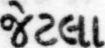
જેટલા
